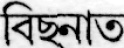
বিছনাত
